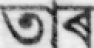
তাৰ
